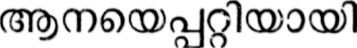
ആനയെപ്പറ്റിയായി
